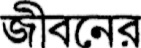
জীবনের
